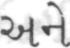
અને
